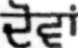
ਦੋਵਾਂ
